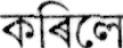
কৰিলে
